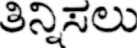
ತಿನ್ನಿಸಲು
